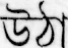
উঠা
